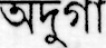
অদুগা
